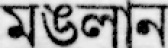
মঙলান
